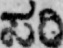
ಪರಿ
